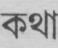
কথা
